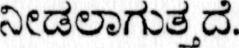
ನೀಡಲಾಗುತ್ತದೆ.
